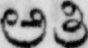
ಅತಿ
